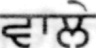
ਵਾਲੇ
